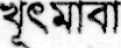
খূৎমাবা
